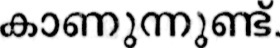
കാണുന്നുണ്ട്.
